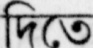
দিতে
